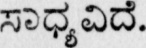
ಸಾಧ್ಯವಿದೆ.
